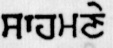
ਸਾਹਮਣੇ
